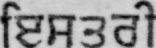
ਇਸਤਰੀ
